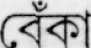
বেঁকা
